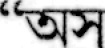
“অস
